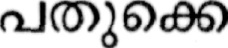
പതുക്കെ
